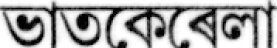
ভাতকেৰেলা
